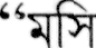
“মসি
